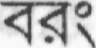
বরং
